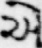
એ
